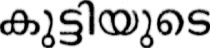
കുട്ടിയുടെ
